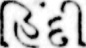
હિંદી
